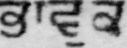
ਭਾਵੁਕ
